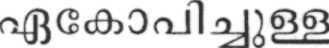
ഏകോപിച്ചുള്ള
